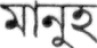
মানুহ
